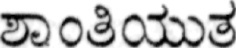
ಶಾಂತಿಯುತ
